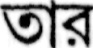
তার
